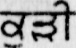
ਕੁੜੀ
